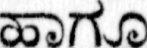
ಹಾಗೂ
